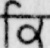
ਕਿ
